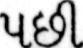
પછી
